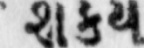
શક્ય
